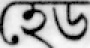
হেড
